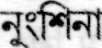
নুংশিনা
